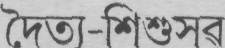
দৈত্য-শিশুসৱ
